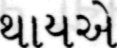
થાયએ
